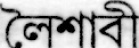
লৈশাবী
